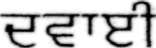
ਦਵਾਈ
